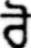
ਰੋ
